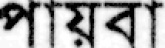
পায়বা
